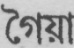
গৈয়া
